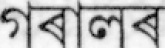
গৰালৰ
